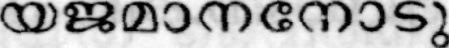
യജമാനനോടു
